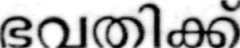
ഭവതിക്ക്
